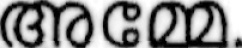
അമ്മേ.
